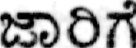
ಜಾರಿಗೆ
